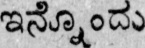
ಇನ್ನೊಂದು
